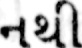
નથી
